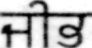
ਜੀਭ
